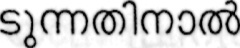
ടുന്നതിനാല്‍
